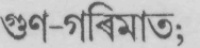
গুণ-গৰিমাত;
